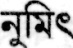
নুমিৎ
